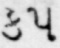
કપ
